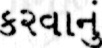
કરવાનું
